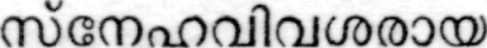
സ്നേഹവിവശരായ
